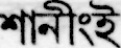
শানীংই
